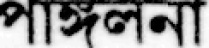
পাঙ্গলনা
